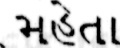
મહેતા
